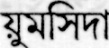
য়ুমসিদা
